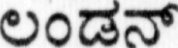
ಲಂಡನ್
